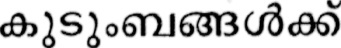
കുടുംബങ്ങള്‍ക്ക്
